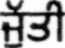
ਜੁੱਤੀ
